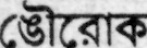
ঙৌরোক
